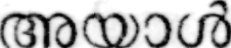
അയാള്‍
